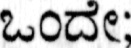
ಒಂದೇ;
